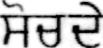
ਸੋਚਦੇ
